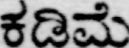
ಕಡಿಮೆ
